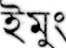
ইমুং
